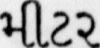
મીટર
